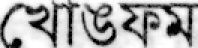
খোঙফম
